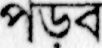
পড়ব
